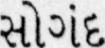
સોગંદ
